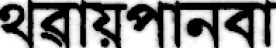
থৱায়পানবা
